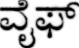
ವೈಫ್
